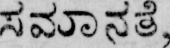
ಸಮಾನತೆ,
